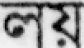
লয়
